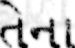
તેના
